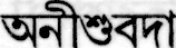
অনীশুবদা
